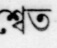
শ্বেত
